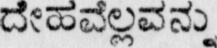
ದೇಹವೆಲ್ಲವನ್ನು
